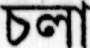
চলা
